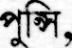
পুন্সি,
